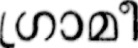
ഗ്രാമീ
